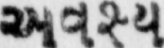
અવશ્ય
